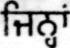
ਜਿਨ੍ਹਾਂ
